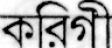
করিগী
